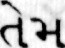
તેમ
